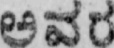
ಅವರ
